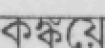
কঙ্কয়ে
